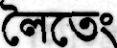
লৈতেং
